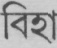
বিহা
